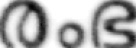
രംഭ
